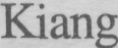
Kiang
